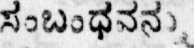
ಸಂಬಂಧವನ್ನು
